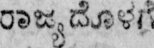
ರಾಜ್ಯದೊಳಗೆ
